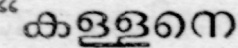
"കള്ളനെ
